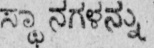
ಸ್ಥಾನಗಳನ್ನು
